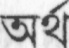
অর্থ
